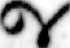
જ
